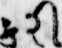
કરી
